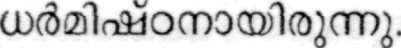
ധര്‍മിഷ്ഠനായിരുന്നു.
